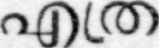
എത്ര
